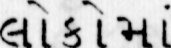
લોકોમાં
